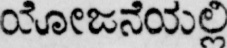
ಯೋಜನೆಯಲ್ಲಿ
